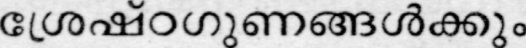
ശ്രേഷ്ഠഗുണങ്ങള്‍ക്കും
